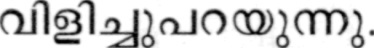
വിളിച്ചുപറയുന്നു.
